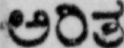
ಅರಿತ
